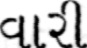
વારી
